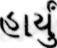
હાર્યું
